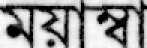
ময়াম্বা
